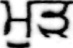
ਮੁੜ
